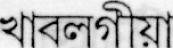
খাবলগীয়া
